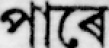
পাৰে
